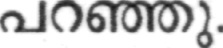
പറഞ്ഞു.
